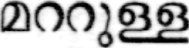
മററുള്ള
